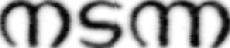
നടന്ന
